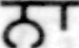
ਨਾ
